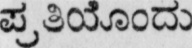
ಪ್ರತಿಯೊಂದು
